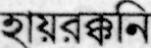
হায়রক্কনি
